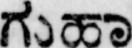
ಗುಹಾ
